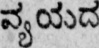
ವ್ಯಯದ
